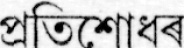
প্রতিশোধৰ
